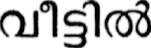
വീട്ടില്‍
